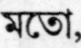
মতো,
